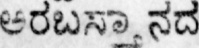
ಅರಬಸ್ತಾನದ
